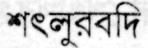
শৎলুরবদি
